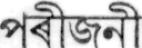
পৰীজনী
